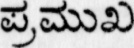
ಪ್ರಮುಖ
